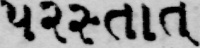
પરસ્તાત્
